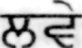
ਲਵੇ
